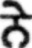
ਨੇ
